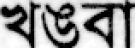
খঙবা
